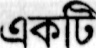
একটি
